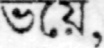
ভয়ে,
